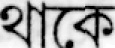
থাকে
